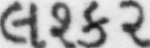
લશ્કર
